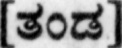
[ತಂಡ]
